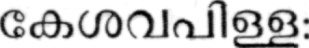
കേശവപിള്ള:
